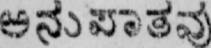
ಅನುಪಾತವು
